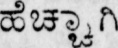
ಹೆಚ್ಚಾಗಿ
